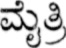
ಮೈತ್ರಿ
